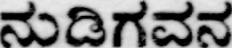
ನುಡಿಗವನ
